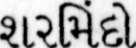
શરમિંદો
